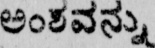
ಅಂಶವನ್ನು
